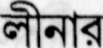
লীনার
